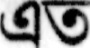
এত
